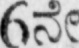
6ನೇ
